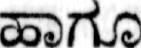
ಹಾಗೂ
